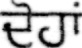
ਦੋਹਾਂ
